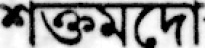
শক্তমদো
